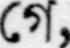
গে,
